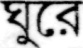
ঘুরে
